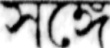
সঙ্গে
